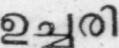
ഉച്ചരി
